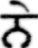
ਨੇ
